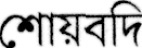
শোয়বদি
